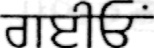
ਗਈਓਂ
